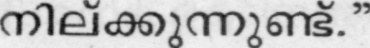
നില്ക്കുന്നുണ്ട്."
